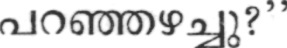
പറഞ്ഞഴച്ചു?"
